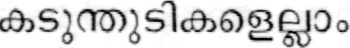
കടുന്തുടികളെല്ലാം
